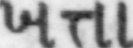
ખત્તા
